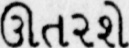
ઊતરશે
